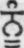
ਨੂੰ
